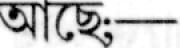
আছে;-
